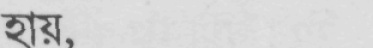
হায়,
